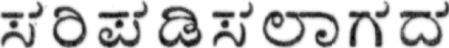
ಸರಿಪಡಿಸಲಾಗದ
